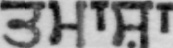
ਤਮਾਸ਼ਾ
